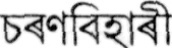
চৰণবিহাৰী
